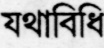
যথাবিধি
